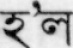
হ'ল
